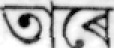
তাৰে
